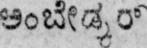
ಅಂಬೇಡ್ಕರ್
